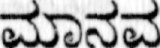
ಮಾನವ
